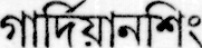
গার্দিয়ানশিং
